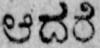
ಆದರೆ
